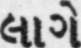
લાગે
